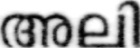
അലി
